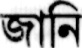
জানি
